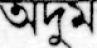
অদুম
